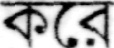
করে
